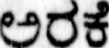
ಅರಕೆ
